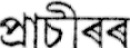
প্রাচীৰৰ
